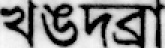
খঙদব্রা
